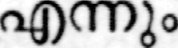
എന്നും
